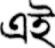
এই
